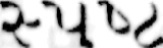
સ્પષ્ટ
